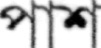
পাশ
